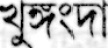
খুঙ্গংদা
